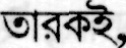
তারকই,
